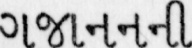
ગજાનનની
